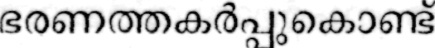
ഭരണത്തകര്‍പ്പുകൊണ്ട്
